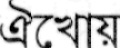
ঐখোয়
